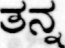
ತನ್ನ
